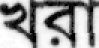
খরা
